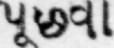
પૂછવા
